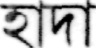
হাদা
